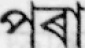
পৰা
